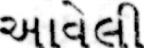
આવેલી
